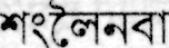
শংলৈনবা
